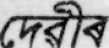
দেৱীৰ
